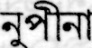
নুপীনা
